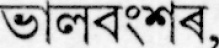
ভালবংশৰ,
